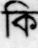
কি
